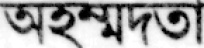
অহম্মদতা
